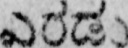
ಎರಡು
